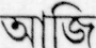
আজি
